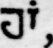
ਹਾਂ,
